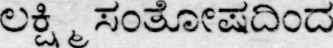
ಲಕ್ಷ್ಮಿಸಂತೋಷದಿಂದ
